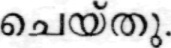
ചെയ്തു.
